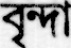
বৃন্দা
